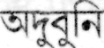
অদুবুনি
